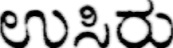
ಉಸಿರು
